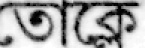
তোক্লে
